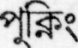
পুক্নিং
